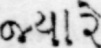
જ્યારે
